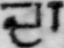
ਦਾ
